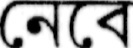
নেবে
